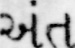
અંત
